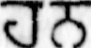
ਹਨ
